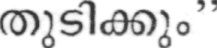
തുടിക്കും”
